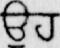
ਉਹ
